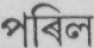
পৰিল
